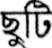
ছুটি
